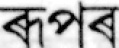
ৰূপৰ
